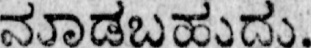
ಮಾಡಬಹುದು.
